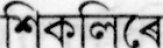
শিকলিৰে
